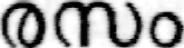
രസം
